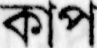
কাপ
